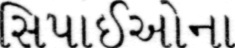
સિપાઈઓના
